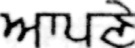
ਆਪਣੇ
